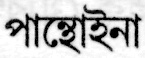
পান্থোইনা
